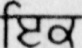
ਇਕ
